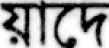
য়াদে
